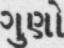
ગુણો
